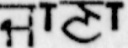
ਜਾਣਾ
